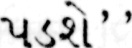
પડશે"
